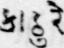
કાઠુરે
